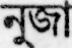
নুজা
